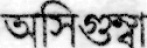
অসিগুম্বা
